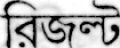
রিজল্ট
